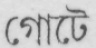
গোটে
